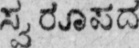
ಸ್ವರೂಪದ
